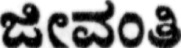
ಜೀವಂತಿ
